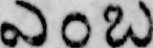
ಎಂಬ
